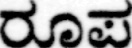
ರೂಪ
